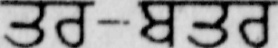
ਤਰ-ਬਤਰ
